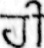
ਹੀ
